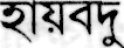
হায়বদু
